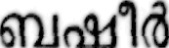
ബഷീര്‍
